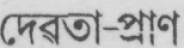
দেৱতা-প্ৰাণ
